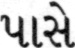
પાસે
